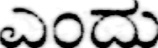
ಎಂದು
